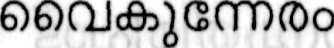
വൈകുന്നേരം
